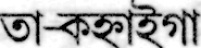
তা-কহ্নাইগা
